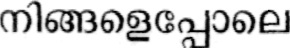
നിങ്ങളെപ്പോലെ
